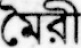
মৈরী
